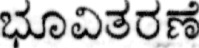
ಭೂವಿತರಣೆ
